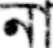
না
